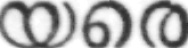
യരെ
